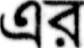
এর
